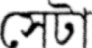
সেটা
